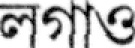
লগাও
